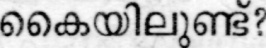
കൈയിലുണ്ട്?
